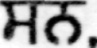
ਸਨ,
